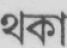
থকা
